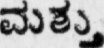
ಮತ್ತು
